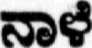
ನಾಳೆ
